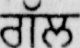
ਗੱਲ
